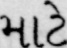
માટે
